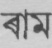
ৰাম
